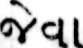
જેવા
